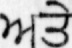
ਅਤੇ
